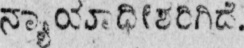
ನ್ಯಾಯಾಧೀಶರಿಗಿದೆ.
